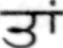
ਤਾਂ
